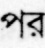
পর
